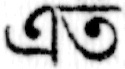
এত
